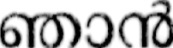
ഞാന്‍
